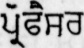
ਪ੍ਰੋਫੈਸਰ
